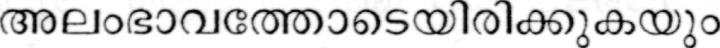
അലംഭാവത്തോടെയിരിക്കുകയും
